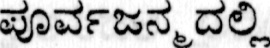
ಪೂರ್ವಜನ್ಮದಲ್ಲಿ
